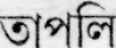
তাপলি
